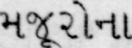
મજૂરોના
